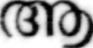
ആ
